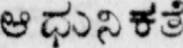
ಆಧುನಿಕತೆ
